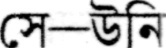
সে–উনি
